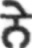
ਨੇ
